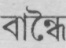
বান্ধৈ
